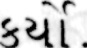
કર્યો.
